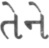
તેને
